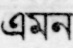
এমন
